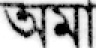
অমা
